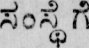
ಸಂಸ್ಥೆಗೆ
